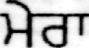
ਮੇਰਾ
